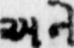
અને
